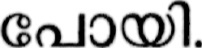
പോയി.
